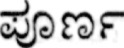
ಪೂರ್ಣ
